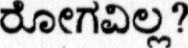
ರೋಗವಿಲ್ಲ?
